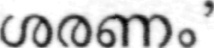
ശരണം’
